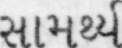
સામર્થ્ય
